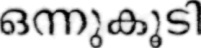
ഒന്നുകൂടി
